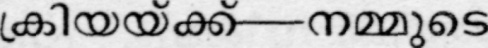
ക്രിയയ്ക്ക്-നമ്മുടെ
